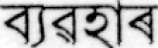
ব্যৱহাৰ
